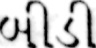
બીડી
